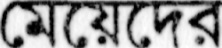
মেয়েদের
